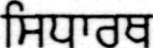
ਸਿਧਾਰਥ
